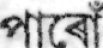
পাৰোঁ
